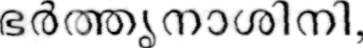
ഭര്‍ത്തൃനാശിനി,
